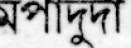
মপাদুদা
